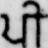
ਪੀ
